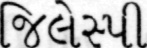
જિલેસ્પી
